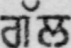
ਗੱਲ
